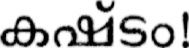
കഷ്ടം!
